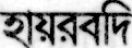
হায়রবদি
